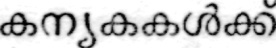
കന്യകകള്‍ക്ക്
